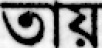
তায়
